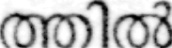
ത്തില്‍
